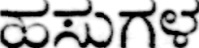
ಹಸುಗಳ
